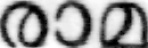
രാമ
